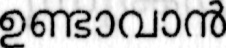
ഉണ്ടാവാന്‍
